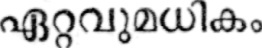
ഏറ്റവുമധികം
